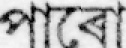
পাৰো
